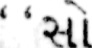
"સો
